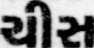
ચીસ
